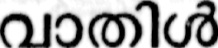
വാതിള്‍
